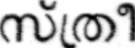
സ്ത്രീ
